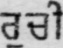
ਰੁਚੀ
